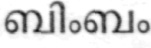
ബിംബം
